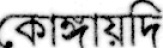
কোঙ্গায়দি
